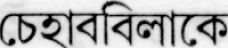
চেহাববিলাকে
